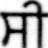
ਸੀ
